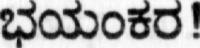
ಭಯಂಕರ!
